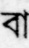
বা
